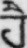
ਹੈ
